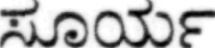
ಸೂರ್ಯ
